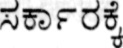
ಸರ್ಕಾರಕ್ಕೆ
